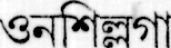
ওনশিল্লগা
